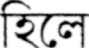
হিলে
